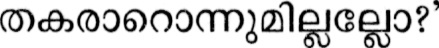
തകരാറൊന്നുമില്ലല്ലോ?’
